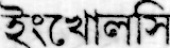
ইংখোলসি
